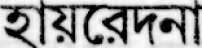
হায়রেদনা
